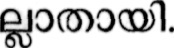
ല്ലാതായി.
